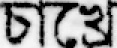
চাখ্রে
